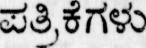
ಪತ್ರಿಕೆಗಳು
